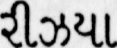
રીઝયા
